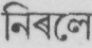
নিৰলে
